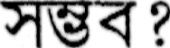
সম্ভব?
